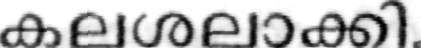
കലശലാക്കി.
